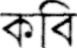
কবি
